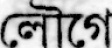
লৌগে
